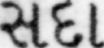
સદા
